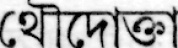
থৌদোক্তা
